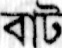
বাট
